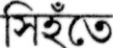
সিহঁতে
